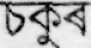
চকুৰ
